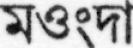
মওংদা
